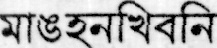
মাঙহনখিবনি
